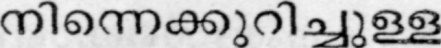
നിന്നെക്കുറിച്ചുള്ള
